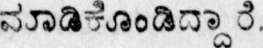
ಮಾಡಿಕೊಂಡಿದ್ದಾರೆ.
